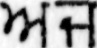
ਅਜ
